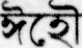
ঈহৌ
